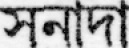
সনাদা
